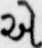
એ
